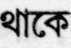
থাকে
